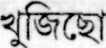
খুজিছো
